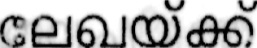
ലേഖയ്ക്ക്
